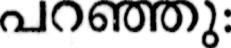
പറഞ്ഞു:
